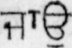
ਜਾਉ
